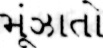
મૂંઝાતો
